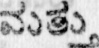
ಮತ್ತು
